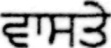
ਵਾਸਤੇ
